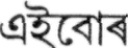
এইবোৰ
